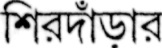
শিরদাঁড়ার
